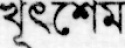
খূৎশেম
